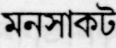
মনসাকট
